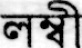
লম্বী
